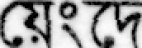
য়েংদে
